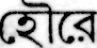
হৌরে
